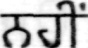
ਨਹੀਂ
